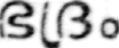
ഭദ്രം
